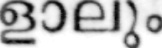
ളാലും
